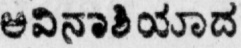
ಅವಿನಾಶಿಯಾದ
